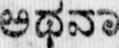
ಅಥವಾ
